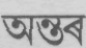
অন্তৰ
